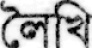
লৈখি
